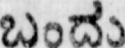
ಬಂದು
